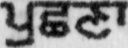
ਪੁਛਣਾ
